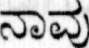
ನಾವು
